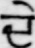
ਦੇ
